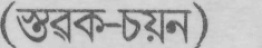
(স্তৱক-চয়ন)
